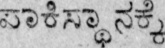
ಪಾಕಿಸ್ಥಾನಕ್ಕೆ
